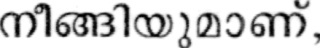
നീങ്ങിയുമാണ്,
